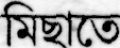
মিছাতে
